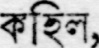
কহিল,
